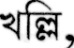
খল্লি,
